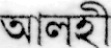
আলহী
